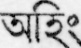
অহিং
